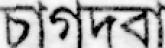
চাগদবা
